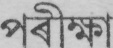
পৰীক্ষা
